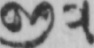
જીવ
